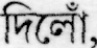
দিলোঁ,
